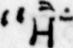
''ਮੈਂ
